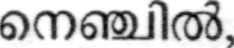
നെഞ്ചില്‍,
